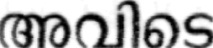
അവിടെ
